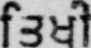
ਤਿਖੀ
